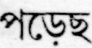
পড়েছ
